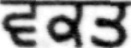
ਵਕਤ
